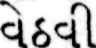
વેઠવી
